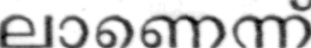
ലാണെന്ന്
